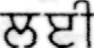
ਲਈ
